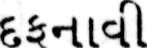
દફનાવી
